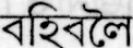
বহিবলৈ
